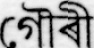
গৌৰী
